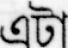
এটা
